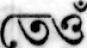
তেওঁ
